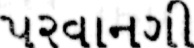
પરવાનગી
